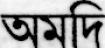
অমদি
